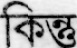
কিন্তু
